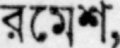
রমেশ,
